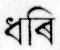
ধৰি
